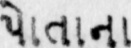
પોતાના
